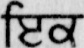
ਇਕ
